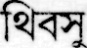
থিবসু
